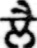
ਲੈ
